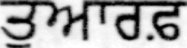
ਤੁਆਰਫ਼
